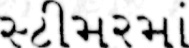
સ્ટીમરમાં
